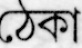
ঠেকা
